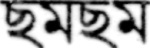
ছমছম
